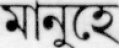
মানুহে
